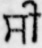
ਸੀ
